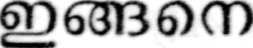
ഇങ്ങനെ
